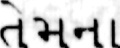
તેમના
